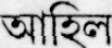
আহিল
